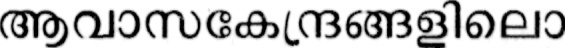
ആവാസകേന്ദ്രങ്ങളിലൊ
